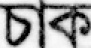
চাক
